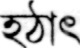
হঠাৎ
